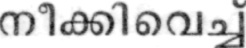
നീക്കിവെച്ച്
